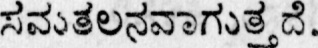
ಸಮತಲನವಾಗುತ್ತದೆ.
